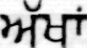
ਅੱਖਾਂ
